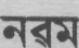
নৱম
